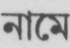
নামে
